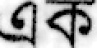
এক
